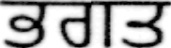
ਭਗਤ
